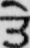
ਤੇ
